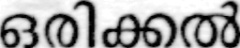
ഒരിക്കല്‍
